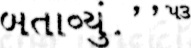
બતાવ્યું."૫૩
